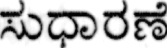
ಸುಧಾರಣೆ
